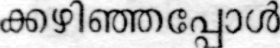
ക്കഴിഞ്ഞപ്പോള്‍
